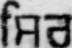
ਸਿਰ
